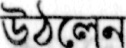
উঠলেন
